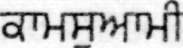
ਕਾਮਸੁਆਮੀ
